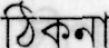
ঠিকনা
